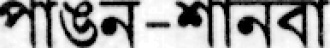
পাঙন-শানবা
